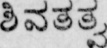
ಶಿವತತ್ವ
